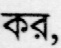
কর,
